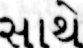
સાથે
